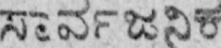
ಸಾರ್ವಜನಿಕ
